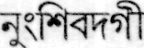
নুংশিবদগী
